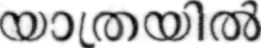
യാത്രയില്‍
